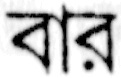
বার
